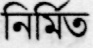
নির্মিত
